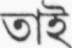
তাই
